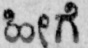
ಹೀಗೆ
